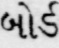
બોર્ડ
